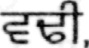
ਵਢੀ,
